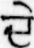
ਦੇ
